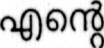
എന്റെ
